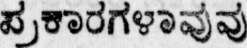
ಪ್ರಕಾರಗಳಾವುವು
